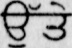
ਉੱਤੇ
